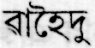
ৱাহৈদু
